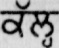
ਕੱਲ੍ਹ
